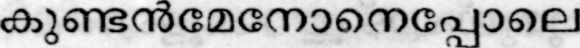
കുണ്ടന്‍മേനോനെപ്പോലെ
